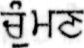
ਚੁੰਮਣ
